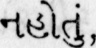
નહોતું,
